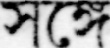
সঙ্গে
